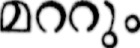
മററും
